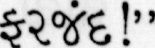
ફરજંદ!"
